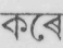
কৰে
